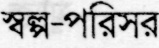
স্বল্প-পরিসর
